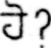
ਹੋ?
